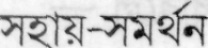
সহায়-সমর্থন
